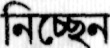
নিচ্ছেন
